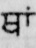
ਥਾਂ
